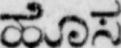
ಹೊಸ
